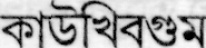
কাউখিবগুম
